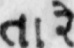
તારે
